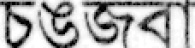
চঙজবা
